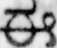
ಈ
